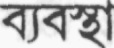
ব্যবস্থা
